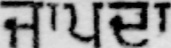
ਜਾਪਦਾ
